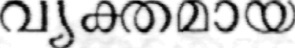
വ്യക്തമായ
